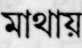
মাথায়
